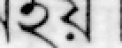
নহয়
